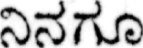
ನಿನಗೂ
